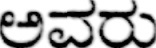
ಅವರು
